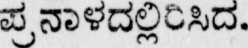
ಪ್ರನಾಳದಲ್ಲಿರಿಸಿದ.
